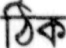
ঠিক
